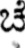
ಚೆ
